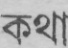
কথা
